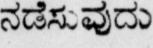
ನಡೆಸುವುದು
